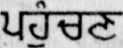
ਪਹੁੰਚਣ
